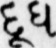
દૂધ
